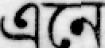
এনে
